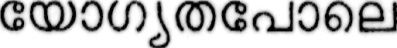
യോഗ്യതപോലെ
